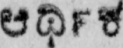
ಆರ್ಥಿಕ
